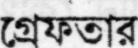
গ্রেফতার
